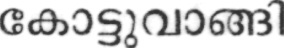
കോട്ടുവാങ്ങി
